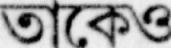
তাকেও
